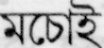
মচোই
